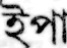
ইপা
